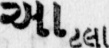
આટલા
